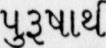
પુરૂષાર્થ
